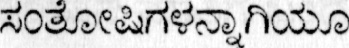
ಸಂತೋಷಿಗಳನ್ನಾಗಿಯೂ
